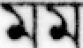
মম
